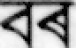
বৰ
